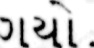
ગયો.
